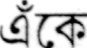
এঁকে
